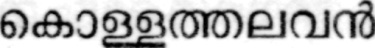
കൊള്ളത്തലവന്‍
